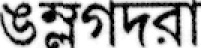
ঙম্লগদরা
